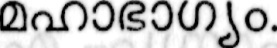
മഹാഭാഗ്യം.
